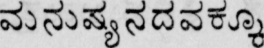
ಮನುಷ್ಯನದವಕ್ಕೂ
